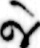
જે
